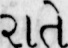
રાતે
